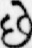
છે
